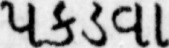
પકડવા
